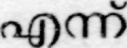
എന്ന്
